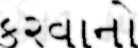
કરવાનો
